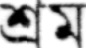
শ্রম
